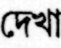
দেখা
